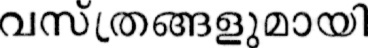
വസ്ത്രങ്ങളുമായി
